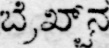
ಬ್ರೆಖ್ಟ್‌ನ
